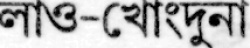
লাও-খোংদুনা
